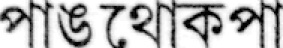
পাঙথোকপা
